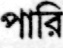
পারি
